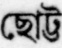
ছোট্ট
